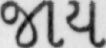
જાય
